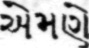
એમણે
